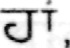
ਹਾਂ,
